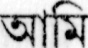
আমি
